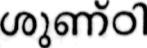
ശുണ്ഠി
